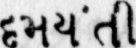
દમયંતી
